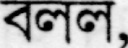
বলল,
